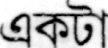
একটা
